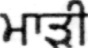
ਮਾੜੀ
